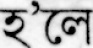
হ'লে
